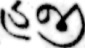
હજી
